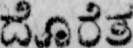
ದೊರೆತ
